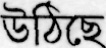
উঠিছে
